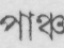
পাঞ্চ
